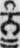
ਨੂੰ
